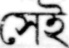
সেই
